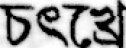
চৎখ্রে
